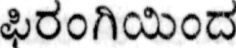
ಫಿರಂಗಿಯಿಂದ
